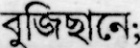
বুজিছানে;
